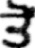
ਤੋਂ
